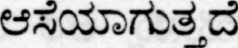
ಆಸೆಯಾಗುತ್ತದೆ
